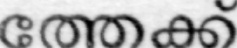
ത്തേക്ക്
